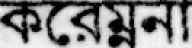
করেম্ননা
